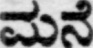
ಮನೆ
